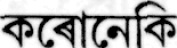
কৰোনেকি
